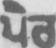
ਪੈਰ
